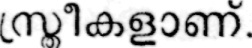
സ്ത്രീകളാണ്.
